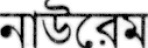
নাউরেম
